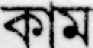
কাম
